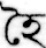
হৈ
